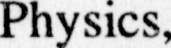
Physics,
